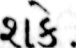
શકે.
